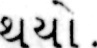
થયો.
